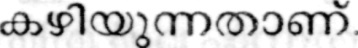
കഴിയുന്നതാണ്.
